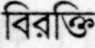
বিরক্তি
